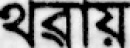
থৱায়
